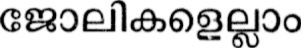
ജോലികളെല്ലാം
